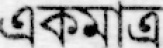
একমাত্র
